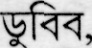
ডুবিব,
